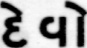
દેવો
